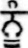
ਨੂੰ
